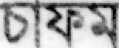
চাফম
